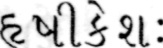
હ્રષીકેશઃ
